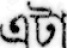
এটা
